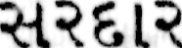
સરદાર
